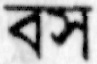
বস
